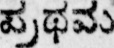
ಪ್ರಥಮ
